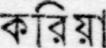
করিয়া
